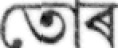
তোৰ
